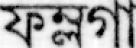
ফম্লগা
